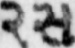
રસ
